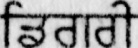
ਡਿਗਰੀ
